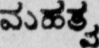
ಮಹತ್ವ
